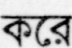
করে
